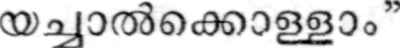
യച്ചാല്‍ക്കൊള്ളാം”
